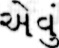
એવું
